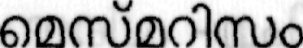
മെസ്മറിസം
